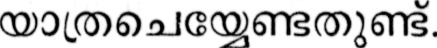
യാത്രചെയ്യേണ്ടതുണ്ട്.
